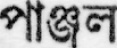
পাঞ্জল
